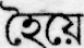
হৈয়ে
